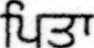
ਪਿਤਾ
